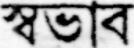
স্বভাব
